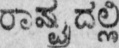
ರಾಷ್ಟ್ರದಲ್ಲಿ
